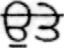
ਉਤੇ
